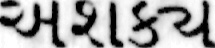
અશક્ય
